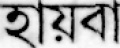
হায়বা
